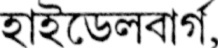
হাইডেলবার্গ,
